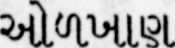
ઓળખાણ
